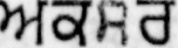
ਅਕਸਰ
